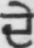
ਦੇ
